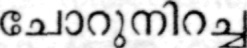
ചോറുനിറച്ച
